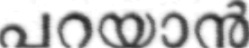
പറയാന്‍
